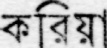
করিয়া
